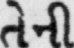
તેની
